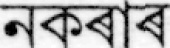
নকৰাৰ
